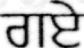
ਗਏ
